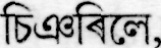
চিঞৰিলে,
